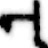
ન
